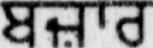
ਬਜ਼ਾਰ
